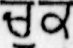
ਚੁਕ
